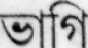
ভাগি
